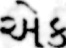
એક
